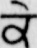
ਕੇ
